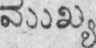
ಮುಖ್ಯ
